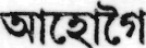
আহোগৈ
